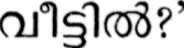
വീട്ടില്‍?’
